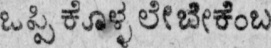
ಒಪ್ಪಿಕೊಳ್ಳಲೇಬೇಕೆಂಬ
